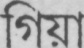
গিয়া
